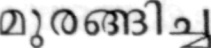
മുരങ്ങിച്ച
